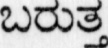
ಬರುತ್ತ
